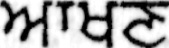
ਆਖਣ
